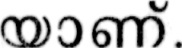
യാണ്.
